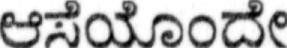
ಆಸೆಯೊಂದೇ
